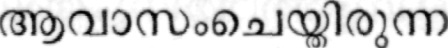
ആവാസംചെയ്തിരുന്ന
